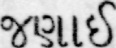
જણાઈ
